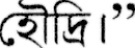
হৌদ্রি।”
